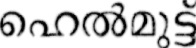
ഹെല്‍മുട്ട്
